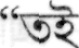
"তই
